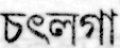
চৎলগা
